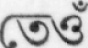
তেওঁ
